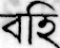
বহি
